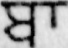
ਬਾ
